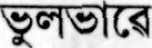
ভুলভাৱে
